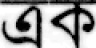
ত্রক
